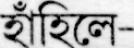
হাঁহিলে-
